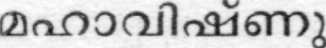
മഹാവിഷ്ണു
